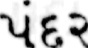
પંદર
